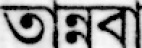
তান্নবা
